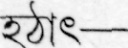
হঠাৎ-
